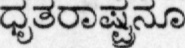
ಧೃತರಾಷ್ಟ್ರನೂ
